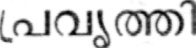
പ്രവൃത്തി
